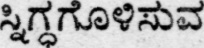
ಸ್ನಿಗ್ಧಗೊಳಿಸುವ
